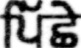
ਪਿੱਛੇ
